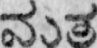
ಮತ
